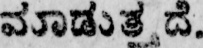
ಮಾಡುತ್ತದೆ.
